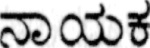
ನಾಯಕ
